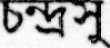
চন্দ্রসু
